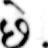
છે.
